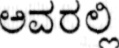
ಅವರಲ್ಲಿ
